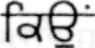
ਕਿਉਂ
